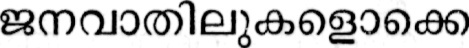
ജനവാതിലുകളൊക്കെ
